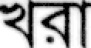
খরা
